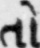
તો
